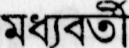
মধ্যবর্তী
